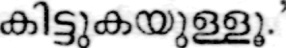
കിട്ടുകയുള്ളൂ.’
